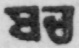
ਬਚ
